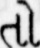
તો
